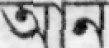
আন
